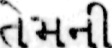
તેમની
